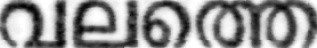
വലത്തെ
